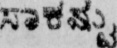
ಸಾಕಷ್ಟು
